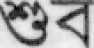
শুব
